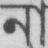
না
